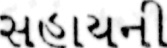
સહાયની
